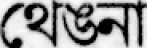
থেঙনা
